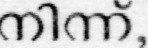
നിന്ന്,
